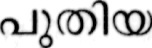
പുതിയ
